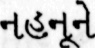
નહનૂને
